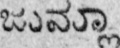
ಜುಮ್ಲಾ
